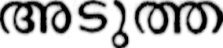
അടുത്ത
